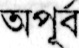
অপূর্ব
